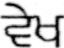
ਵੇਖ
